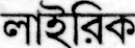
থোক্তবা,লাইরিক
